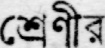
শ্রেণীর
